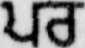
ਪਰ
